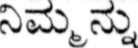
ನಿಮ್ಮನ್ನು
